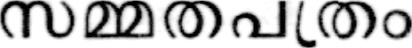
സമ്മതപത്രം
